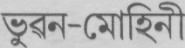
ভুৱন-মোহিনী
